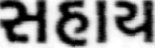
સહાય
